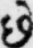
છે
